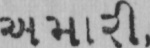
અમારી.
